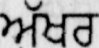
ਅੱਖਰ
